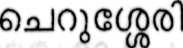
ചെറുശ്ശേരി
